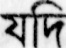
যদি
